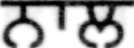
ਨਾਲ
